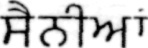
ਸੈਨੀਆਂ
